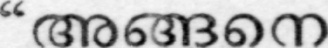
"അങ്ങനെ
